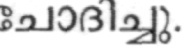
ചോദിച്ചു.
